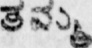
ತಮ್ಮ
